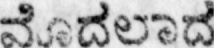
ಮೊದಲಾದ
